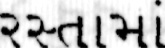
રસ્તામાં
